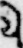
યે
